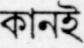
কানই
